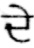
ਦੇ
